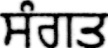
ਸੰਗਤ
